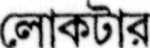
লোকটার
